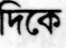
দিকে
